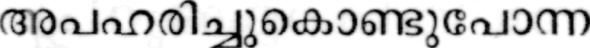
അപഹരിച്ചുകൊണ്ടുപോന്ന
